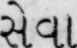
સેવા
